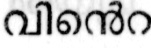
വിന്റെ
